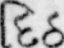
દિઠ
